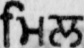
ਮਿਲ
